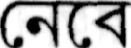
নেবে
